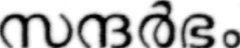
സന്ദര്‍ഭം
